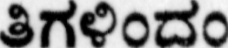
ತಿಗಳಿಂದಂ
